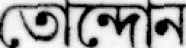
তোন্দোন
